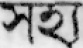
সহ্য
